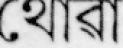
থোৱা
